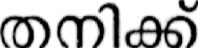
തനിക്ക്
